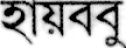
হায়ববু
